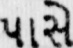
પાસે
